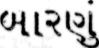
બારણું
